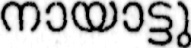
നായാട്ടു
